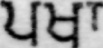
ਪਖਾ
